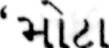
'મોટા
